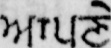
ਆਪਣੇ
